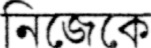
নিজেকে
